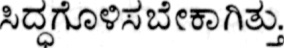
ಸಿದ್ಧಗೊಳಿಸಬೇಕಾಗಿತ್ತು.
